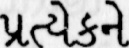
પ્રત્યેકને
